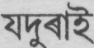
যদুৰাই
